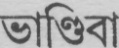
ভাণ্ডিবা
